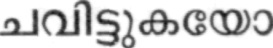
ചവിട്ടുകയോ
